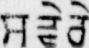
ਸਵੇਰੇ
